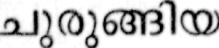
ചുരുങ്ങിയ
